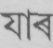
যাৰ
